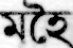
মহৈ
